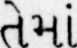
તેમાં
